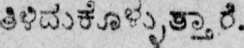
ತಿಳಿದುಕೊಳ್ಳುತ್ತಾರೆ.
